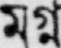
মগ্ন
